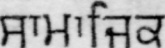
ਸਾਮਾਜਿਕ
